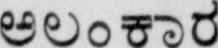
ಅಲಂಕಾರ
